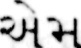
એમ
